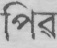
পিৱ
